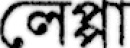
লেপ্পা
